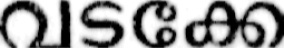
വടക്കേ
